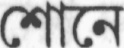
শোনে
